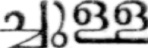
ച്ചുള്ള
